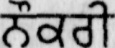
ਨੌਕਰੀ
